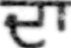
ਦਾ
